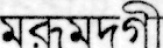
মরূমদগী
